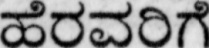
ಹೆರವರಿಗೆ
